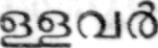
ള്ളവര്‍
